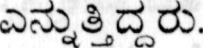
ಎನ್ನುತ್ತಿದ್ದರು.
